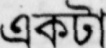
একটা
